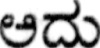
ಅದು
